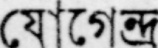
যোগেন্দ্র
